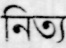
নিত্য
